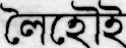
লৈহৌই
